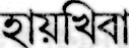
হায়খিবা
